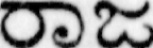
ರಾಜ
